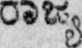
ರಾಜ್ಯ
